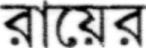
রায়ের
